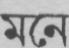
মনে
